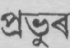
প্ৰভুৰ
